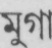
মুগা
